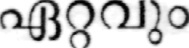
ഏറ്റവും
